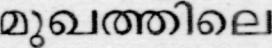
മുഖത്തിലെ
